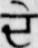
ਦੇ
